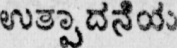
ಉತ್ಪಾದನೆಯ
